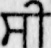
ਸੀ
